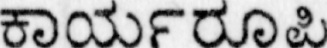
ಕಾರ್ಯರೂಪಿ
